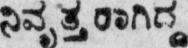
ನಿವೃತ್ತರಾಗಿದ್ದ
